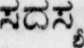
ಸದಸ್ಯ
